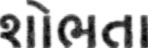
શોભતા
